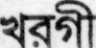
খরগী
